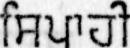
ਸਿਪਾਹੀ
